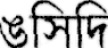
ঙসিদি
